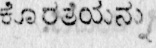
ಕೊರತೆಯನ್ನು
